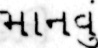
માનવું
